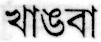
খাঙবা
